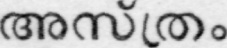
അസ്ത്രം
